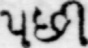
પછી
